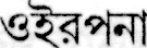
ওইরপনা
